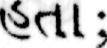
હતા;
